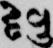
દેવુ
